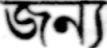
জন্য
